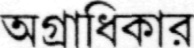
অগ্রাধিকার
